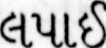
લપાઈ
